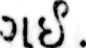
ગઈ.
